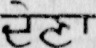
ਦੇਣਾ
